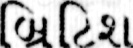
બ્રિટિશ
